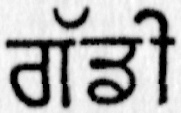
ਗੱਡੀ
